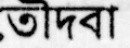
তৌদবা
